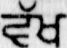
ਵੱਖ
